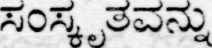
ಸಂಸ್ಕೃತವನ್ನು
